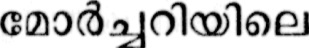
മോര്‍ച്ചറിയിലെ
